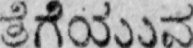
ತೆಗೆಯುವ
